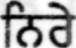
ਨਿਰੇ
